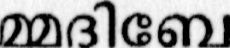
മ്മദിബേ
